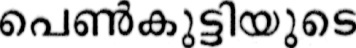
പെണ്‍കുട്ടിയുടെ
